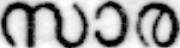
സാര
